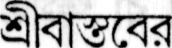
শ্রীবাস্তবের
